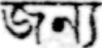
জন্য
